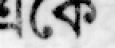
একে
